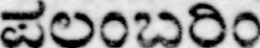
ಪಲಂಬರಿಂ
